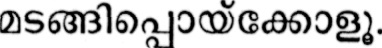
മടങ്ങിപ്പൊയ്ക്കോളൂ.
